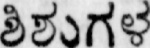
ಶಿಶುಗಳ
